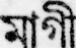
মাগী
